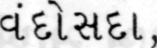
વંદોસદા,
